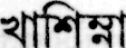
খাশিম্না
